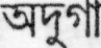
অদুগা
